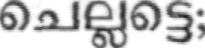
ചെല്ലട്ടെ;
